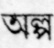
অল্প
